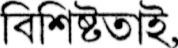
বিশিষ্টতাই,
